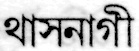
থাসনাগী
